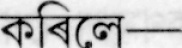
কৰিলে-
